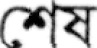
শেষ
